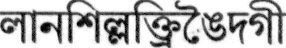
লানশিল্লক্ত্রিঙৈদগী
